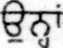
ਉਨ੍ਹਾਂ
